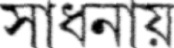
সাধনায়
